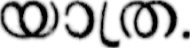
യാത്ര.
